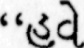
"હવે
